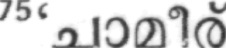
75'ചാമീര്
